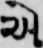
એ
